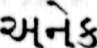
અનેક
